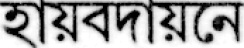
হায়বদায়নে
